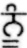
ਨੂੰ
